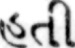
હતી
